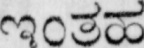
ಇಂತಹ
